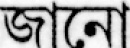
জানো
